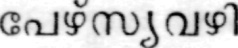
പേഴ്സ്യവഴി
